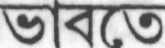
ভাবতে
